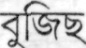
বুজিছ
